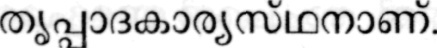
തൃപ്പാദകാര്യസ്ഥനാണ്.
